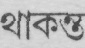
থাকন্ত
